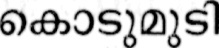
കൊടുമുടി
